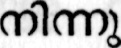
നിന്നു
